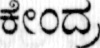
ಕೇಂದ್ರ
